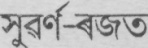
সুৱৰ্ণ-ৰজত
